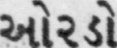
ઓરડો
